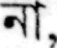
না,
